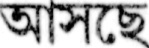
আসছে
